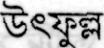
উৎফুল্ল
